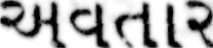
અવતાર
